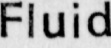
Fluid
